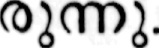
രുന്നു.
